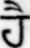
ਹੈ
